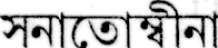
সনাতোম্বীনা
